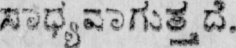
ಸಾಧ್ಯವಾಗುತ್ತದೆ.
